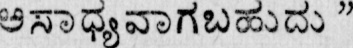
ಅಸಾಧ್ಯವಾಗಬಹುದು”
